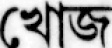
খোজ
